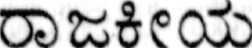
ರಾಜಕೀಯ
